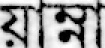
য়াম্না
